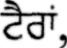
ਟੈਰਾਂ,
